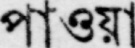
পাওয়া
